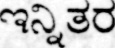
ಇನ್ನಿತರ
